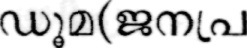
ഡൂമ(ജനപ്ര
